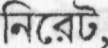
নিরেট,
